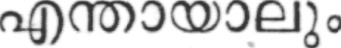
എന്തായാലും
